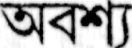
অবশ্য
